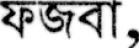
ফজবা,
